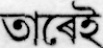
তাৰেই
